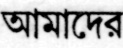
আমাদের
